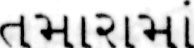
તમારામાં
